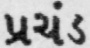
પ્રચંડ
